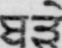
ਬੜੇ
